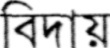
বিদায়
